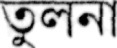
তুলনা
